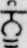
ਨੂੰ
